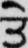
ਤੇ
